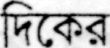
দিকের
